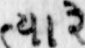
ત્યારે
